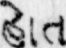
હોત
